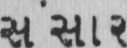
સંસાર
